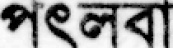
পৎলবা
